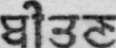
ਬੀਤਣ
